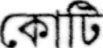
কোটি
